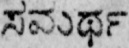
ಸಮರ್ಥ
